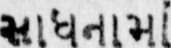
સાધનામાં
